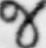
જ
